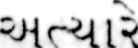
અત્યારે
